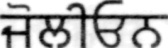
ਜੋਲੀਓਨ
